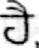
ਹੈ,
